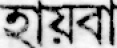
হায়বা
